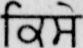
ਕਿਸੇ
